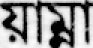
য়াম্না
